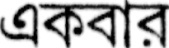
একবার
